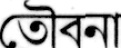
তৌবনা
